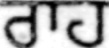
ਰਾਹ
